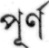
পূর্ণ
